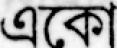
একো
